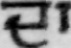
ਦਾ
